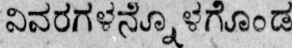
ವಿವರಗಳನ್ನೊಳಗೊಂಡ
